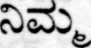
ನಿಮ್ಮ
